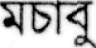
মচাবু
